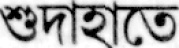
শুদাহাতে
